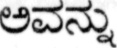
ಅವನ್ನು
